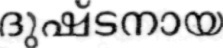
ദുഷ്ടനായ
